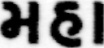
મહા
